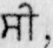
ਸੀ,
